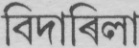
বিদাৰিলা
